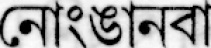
নোংঙানবা
